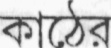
কাঠের
